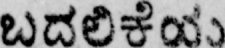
ಬದಲಿಕೆಯ
